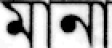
মানা
